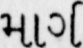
માર્ગ
